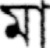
মা
